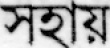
সহায়
